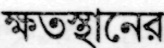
ক্ষতস্থানের
